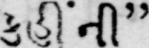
કહીંની"
